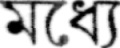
মধ্যে
